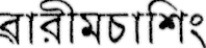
ৱারীমচাশিং
